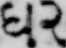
ઘર
